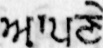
ਆਪਣੇ
